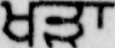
ਖੜਾ
